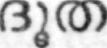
ദൂത
